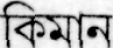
কিমান
